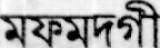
মফমদগী
